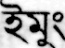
ইমুং
